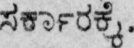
ಸರ್ಕಾರಕ್ಕೆ.
